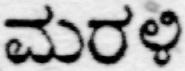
ಮರಳಿ
